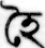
হৈ
